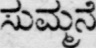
ಸುಮ್ಮನೆ
